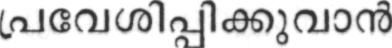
പ്രവേശിപ്പിക്കുവാന്‍
